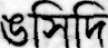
ঙসিদি
